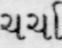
ચર્ચા
